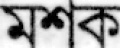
মশক
